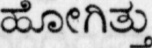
ಹೋಗಿತ್ತು
